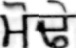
ਮੋਢੇ
